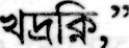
খদ্রক্নি,”
